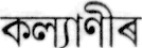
কল্যাণীৰ
